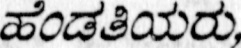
ಹೆಂಡತಿಯರು,
